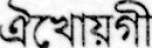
ঐখোয়গী
